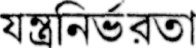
যন্ত্রনির্ভরতা
